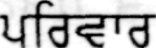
ਪਰਿਵਾਰ
